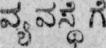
ವ್ಯವಸ್ಥೆಗೆ
